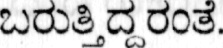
ಬರುತ್ತಿದ್ದರಂತೆ.
